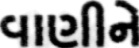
વાણીને
